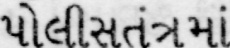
પોલીસતંત્રમાં
